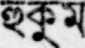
হুকুম
